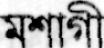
মশাগী
